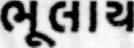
ભૂલાય
